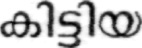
കിട്ടിയ
